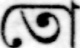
তো
